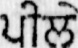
ਪੀਲੇ
